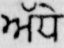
ਅੱਧੇ
